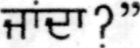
ਜਾਂਦਾ?''
